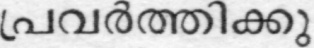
പ്രവര്‍ത്തിക്കു
